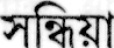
সন্ধিয়া
